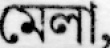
মেলা,
